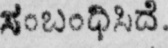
ಸಂಬಂಧಿಸಿದೆ.
